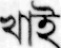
খাই
